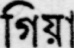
গিয়া
